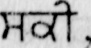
ਸਕੀ,
